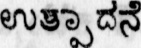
ಉತ್ಪಾದನೆ
